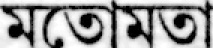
মতোমতা
